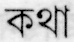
কথা
